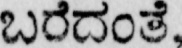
ಬರದಂತೆ,
